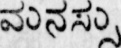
ಮನಸ್ಸು
